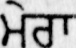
ਮੇਰਾ
